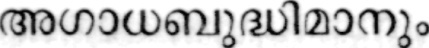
അഗാധബുദ്ധിമാനും
